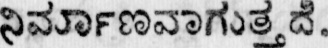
ನಿರ್ಮಾಣವಾಗುತ್ತದೆ.
